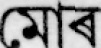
মোৰ
